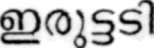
ഇരുട്ടടി
